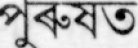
পুৰুষত
